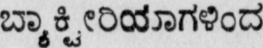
ಬ್ಯಾಕ್ಟೀರಿಯಾಗಳಿಂದ
